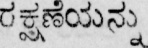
ರಕ್ಷಣೆಯನ್ನು
